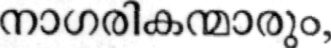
നാഗരികന്മാരും,
